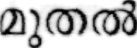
മുതല്‍
